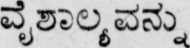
ವೈಶಾಲ್ಯವನ್ನು
